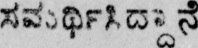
ಸಮರ್ಥಿಸಿದ್ದಾನೆ
